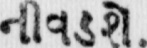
નીવડશે.
